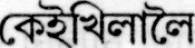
কেইখিলালৈ
